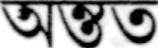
অন্তত
